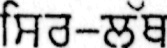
ਸਿਰ-ਲੱਥ
